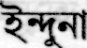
ইন্দুনা
